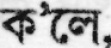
ক'লে,
